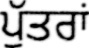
ਪੁੱਤਰਾਂ
